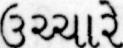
ઉચ્ચારે
